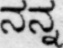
ನನ್ನ
